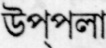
উপ্পলা
